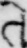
તે
